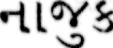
નાજુક
